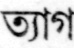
ত্যাগ
